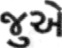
જુએ
